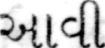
આવી
